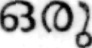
ഒരു
